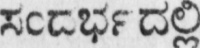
ಸಂದರ್ಭದಲ್ಲಿ
